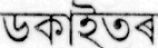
ডকাইতৰ
